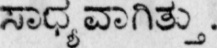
ಸಾಧ್ಯವಾಗಿತ್ತು.
